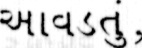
આવડતું,
